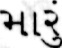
મારું
